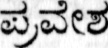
ಪ್ರವೇಶ
